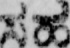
ಸಹ
